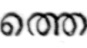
ത്തെ
